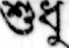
শুধু
